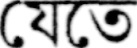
যেতে
